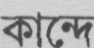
কান্দে
